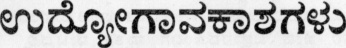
ಉದ್ಯೋಗಾವಕಾಶಗಳು
